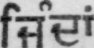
ਜਿੰਦਾਂ
